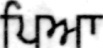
ਪਿਆ
